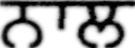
ਨਾਲ
